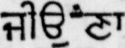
ਜੀਉਂਣਾ
